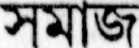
সমাজ
